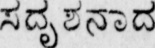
ಸದೃಶನಾದ
